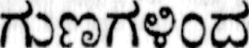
ಗುಣಗಳಿಂದ
